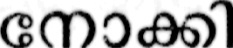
നോക്കി
